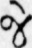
જે
